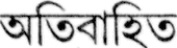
অতিবাহিত
